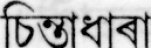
চিন্তাধাৰা
